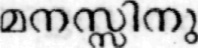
മനസ്സിനു
